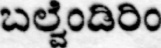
ಬಲ್ವೆಂಡಿರಿಂ
